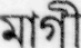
মাগী
